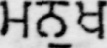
ਮਨੁਖ
